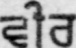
ਵੀਰ
